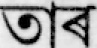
তাৰ
